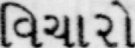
વિચારો
